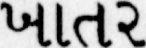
ખાતર
